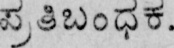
ಪ್ರತಿಬಂಧಕ.
